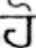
ਹੋ
